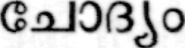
ചോദ്യം
